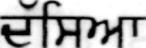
ਦੱਸਿਆ
